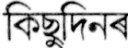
কিছুদিনৰ
